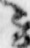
કે
